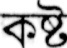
কষ্ট
